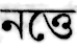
নত্তে
